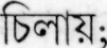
চিলায়;
